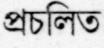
প্রচলিত
